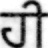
ਹੀ
